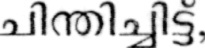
ചിന്തിച്ചിട്ട്,
